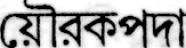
য়ৌরকপদা
